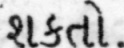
શકતો.
